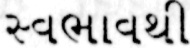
સ્વભાવથી
